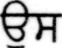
ਉਸ
